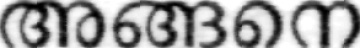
അങ്ങനെ
